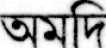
অমদি
